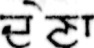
ਦੇਣਾ
